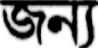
জন্য
